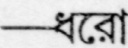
–ধরো
